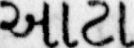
આટા
